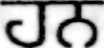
ਹਨ
